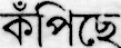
কঁপিছে
